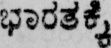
ಭಾರತಕ್ಕೆ
